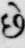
છે
